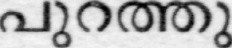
പുറത്തു
